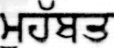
ਮੁਹੱਬਤ
